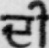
ਦੀ
